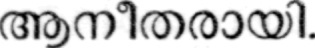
ആനീതരായി.
